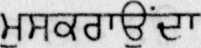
ਮੁਸਕਰਾਉਂਦਾ
